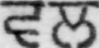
ਵਲ
